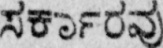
ಸರ್ಕಾರವು
